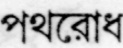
পথরোধ
